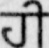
ਹੀ
